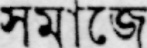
সমাজে
